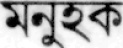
মনুহক
